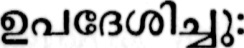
ഉപദേശിച്ചു:
